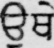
ਉਥੇ
